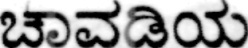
ಚಾವಡಿಯ
